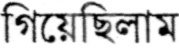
গিয়েছিলাম
